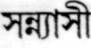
সন্ন্যাসী
